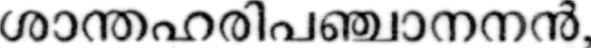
ശാന്തഹരിപഞ്ചാനനന്‍,
